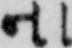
ના
